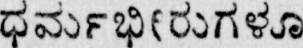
ಧರ್ಮಭೀರುಗಳೂ
